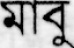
মাবু
